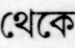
থেকে
